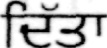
ਦਿੱਤਾ
